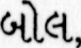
બોલ,
